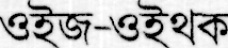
ওইজ-ওইথক
